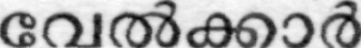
വേല്‍ക്കാര്‍
